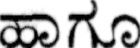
ಹಾಗೂ
